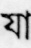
যা
